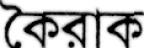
কৈরাক
